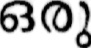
ഒരു
